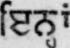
ਇਨ੍ਹਾਂ
